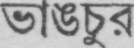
ভাঙচুর
